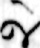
જે
